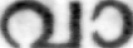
വാ
